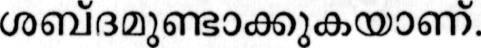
ശബ്ദമുണ്ടാക്കുകയാണ്.
